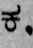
ಕ.
